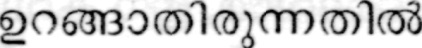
ഉറങ്ങാതിരുന്നതില്‍
